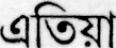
এতিয়া
